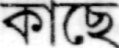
কাছে
